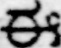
ಈ
